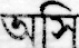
অসি
